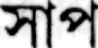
সাপ
